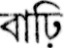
বাঢ়ি
